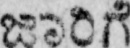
ಜಾರಿಗೆ
